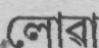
লোৱা
